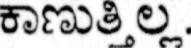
ಕಾಣುತ್ತಿಲ್ಲ.
